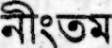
নীংতম
